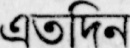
এতদিন
